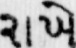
રાખે
